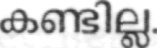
കണ്ടില്ല.
